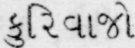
કુરિવાજો
